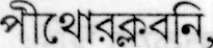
পীথোরক্লবনি,
